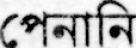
পেনানি
